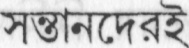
সন্তানদেরই
